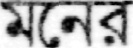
মনের
